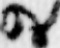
જ
